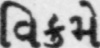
વિક્રમે
